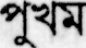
পুখম
